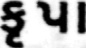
કૃપા
